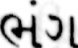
ભંગ
